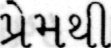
પ્રેમથી
